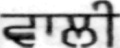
ਵਾਲੀ
